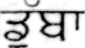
ਡੁੱਬਾ
